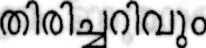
തിരിച്ചറിവും
